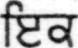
ਇਕ
